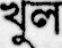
খুল
